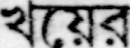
খয়ের
